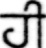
ਹੀ
